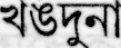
খঙদুনা
